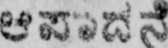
ಆಪಾದನೆ
